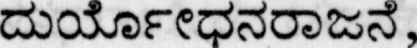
ದುರ್ಯೋಧನರಾಜನೆ,
